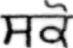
ਸਕੋ
